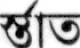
র্স্তাত
